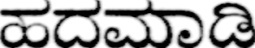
ಹದಮಾಡಿ
